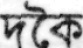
দকৈ
